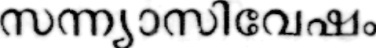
സന്ന്യാസിവേഷം
